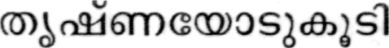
തൃഷ്ണയോടുകൂടി
